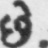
છે.
